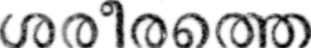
ശരീരത്തെ
